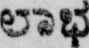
ಲಾಭ
